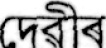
দেৱীৰ
